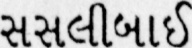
સસલીબાઈ
